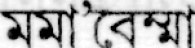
মমা’বেম্মা
